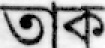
তাক
